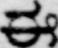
ಈ
